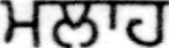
ਮਲਾਹ
